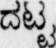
ದಟ್ಟ
